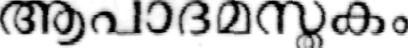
ആപാദമസ്തകം
